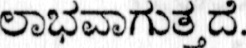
ಲಾಭವಾಗುತ್ತದೆ.
